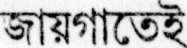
জায়গাতেই
